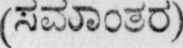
(ಸಮಾಂತರ)
